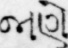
જાણે
